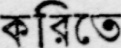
করিতে
